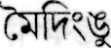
মৈদিংঙু
